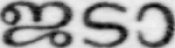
ജടാ
